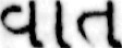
વાત
